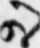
જે
